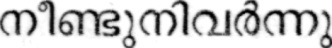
നീണ്ടുനിവര്‍ന്നു
